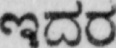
ಇದರ
